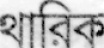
থারিক
